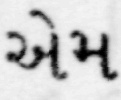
એમ
